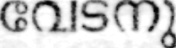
വേടനു
